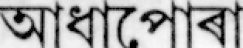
আধাপোৰা
